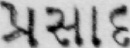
પ્રસાદ
